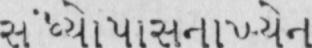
સંધ્યોપાસનાખ્યેન
